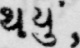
થયું,
